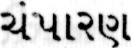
ચંપારણ
